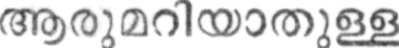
ആരുമറിയാതുള്ള
